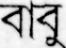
বাবু
